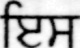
ਇਸ
